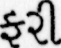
ફરી
